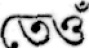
তেওঁ
